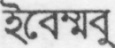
ইবেম্মবু
